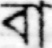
বা
